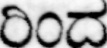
ರಿಂದ
